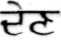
ਦੇਣ
